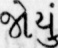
જોયું
